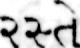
રસ્તે
